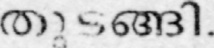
തുടങ്ങി.
